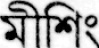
মীশিং
